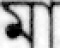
মা
